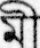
মী
